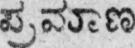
ಪ್ರಮಾಣ
